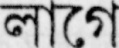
লাগে
